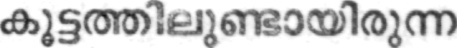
കൂട്ടത്തിലുണ്ടായിരുന്ന
